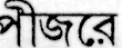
পীজরে
